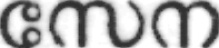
സേന
